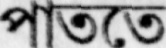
পাততে
